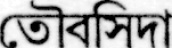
তৌবসিদা
